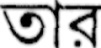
তার
